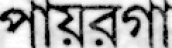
পায়রগা
